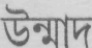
উন্মাদ
